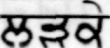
ਲੜਕੇ
